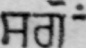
ਸਗੋਂ
